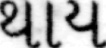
થાય
